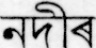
নদীৰ
